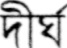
দীর্ঘ
